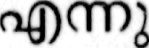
എന്നു
